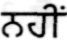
ਨਹੀਂ
